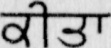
ਕੀਤਾ
